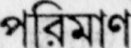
পরিমাণ
